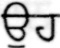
ਉਹ
